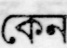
কেন
